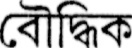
বৌদ্ধিক
